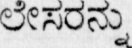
ಲೇಸರನ್ನು
